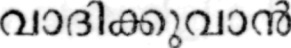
വാദിക്കുവാന്‍
